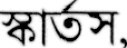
স্কার্তস,
